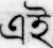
এই
